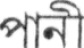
পানী
